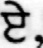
ਏ,
